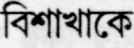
বিশাখাকে
